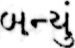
બન્યું
